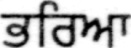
ਭਰਿਆ
